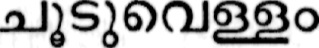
ചൂടുവെള്ളം
